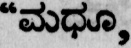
“ಮಧೂ,
